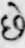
છે
